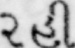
રહી
